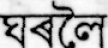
ঘৰলৈ
